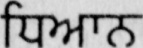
ਧਿਆਨ
